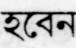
হবেন
